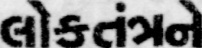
લોકતંત્રને
